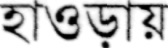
হাওড়ায়
